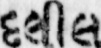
દલીલ
